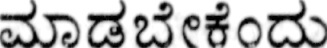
ಮಾಡಬೇಕೆಂದು
